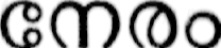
നേരം
